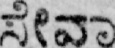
ಸೇವಾ
